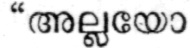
“അല്ലയോ
